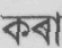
কৰা
